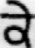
ਕੇ
